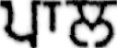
ਪਾਲ
